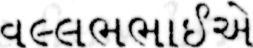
વલ્લભભાઈએ
